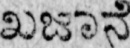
ಖಜಾನೆ
